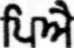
ਪਿਐ
